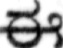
ಈ
